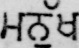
ਮਨੁੱਖ
